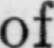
of
